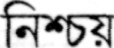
নিশ্চয়
